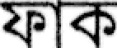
ফাক
